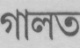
গালত
